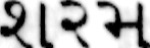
શરમ
